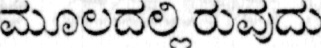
ಮೂಲದಲ್ಲಿರುವುದು
